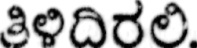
ತಿಳಿದಿರಲಿ.
